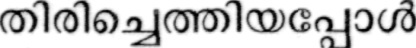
തിരിച്ചെത്തിയപ്പോള്‍
